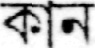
কান
